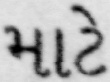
માટે
